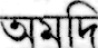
অমদি
